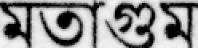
মতাগুম
